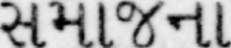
સમાજના
